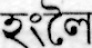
হংলৈ
